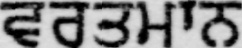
ਵਰਤਮਾਨ
